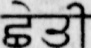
ਛੇਤੀ
